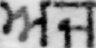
ਅਜ
